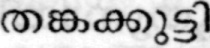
തങ്കക്കുട്ടി
